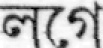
লগে
